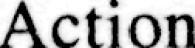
Action
